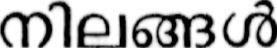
നിലങ്ങള്‍
